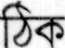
ঠিক
